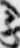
કે
